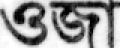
ওজা
